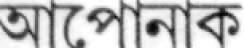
আপোনাক
